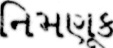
નિમણૂક
